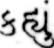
કહ્યું
